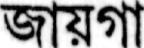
জায়গা
